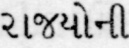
રાજ્યોની
